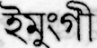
ইমুংগী
